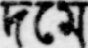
দমে
